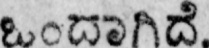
ಒಂದಾಗಿದೆ.
